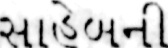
સાહેબની
